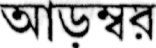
আড়ম্বর
